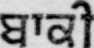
ਬਾਕੀ
